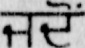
ਜਦੋਂ
